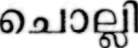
ചൊല്ലി
